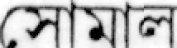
সোমাল
